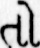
તો
